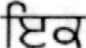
ਇਕ
